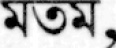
মতম,
